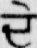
ਦੇ
